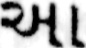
આ
